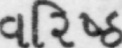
વરિષ્ઠ
